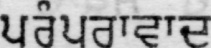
ਪਰੰਪਰਾਵਾਦ
